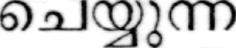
ചെയ്യുന്ന
